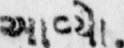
આવ્યો.
